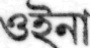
ওইনা
